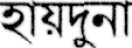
হায়দুনা
